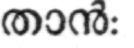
താന്‍:
